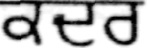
ਕਦਰ
